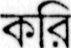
করি
